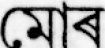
মোৰ
